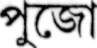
পুজো
